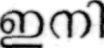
ഇനി
